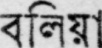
বলিয়া
